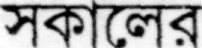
সকালের
